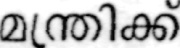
മന്ത്രിക്ക്
